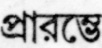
প্রারম্ভে
